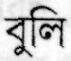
বুলি
